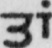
ਤਾਂ
